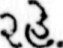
રહે.
